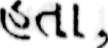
હતા,
